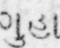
ગુહા
